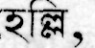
হেল্লি,
